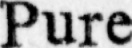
Pure
